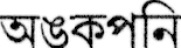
অঙকপনি
